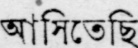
আসিতেছি
